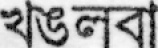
খঙলবা
